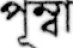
পূম্বা
